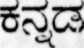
ಕನ್ನಡ
